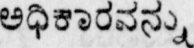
ಅಧಿಕಾರವನ್ನು
